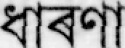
ধাৰণা
